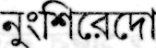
নুংশিরেদো
